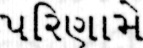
પરિણામે
